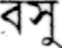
বসু
